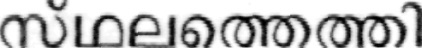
സ്ഥലത്തെത്തി
